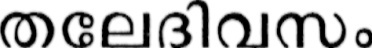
തലേദിവസം
